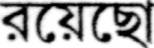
রয়েছো
